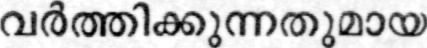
വര്‍ത്തിക്കുന്നതുമായ
